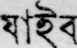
যাইব
